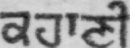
ਕਹਾਣੀ
